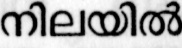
നിലയില്‍
